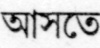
আসতে
